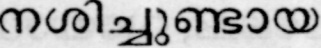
നശിച്ചുണ്ടായ
